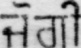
ਜੋਗੀ
